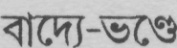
বাদ্যে-ভণ্ডে
